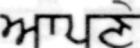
ਆਪਣੇ
